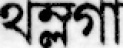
থম্লগা
